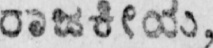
ರಾಜಕೀಯ,
